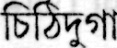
চিঠিদুগা
